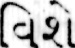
વિશે
